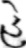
હે
